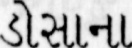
ડોસાના
